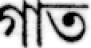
গাত
